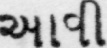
આવી
